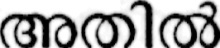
അതില്‍
